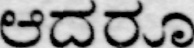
ಆದರೂ
